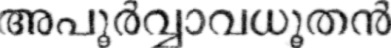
അപൂര്‍വ്വാവധൂതന്‍
